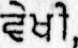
ਵੇਖੀ,
